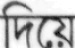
দিয়ে
